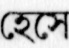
হেসে
